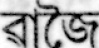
ৱাজৈ
